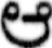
ಆ
